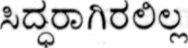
ಸಿದ್ಧರಾಗಿರಲಿಲ್ಲ
